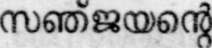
സഞ്ജയന്റെ
